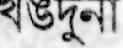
খঙদুনা
